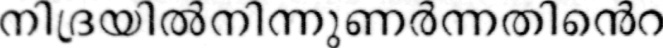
നിദ്രയില്‍നിന്നുണര്‍ന്നതിന്റെ
